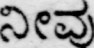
ನೀವು
